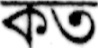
কত
